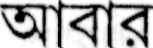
আবার
